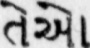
તેઓ
